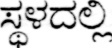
ಸ್ಥಳದಲ್ಲಿ
